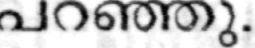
പറഞ്ഞു.
